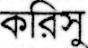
করিসু
